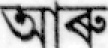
আৰু
